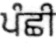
ਪੰਛੀ
